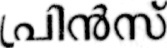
പ്രിന്‍സ്
